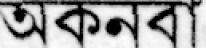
অকনবা
